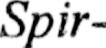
Spir-
